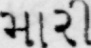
મારી
